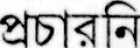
প্রচারনি
